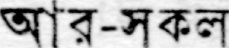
আর-সকল
